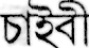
চাইবী
